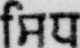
ਸਿਧ
